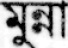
মুন্না
